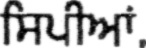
ਸਿਪੀਆਂ,
